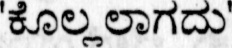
‘ಕೊಲ್ಲಲಾಗದು”
